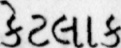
કેટલાક
